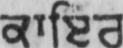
ਕਾਇਰ
